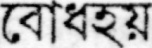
বোধহয়
